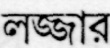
লজ্জার
